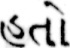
હતો
